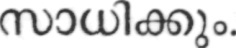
സാധിക്കും.
